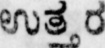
ಉತ್ತರ
